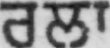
ਰਲਾ
